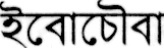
ইবোচৌবা
